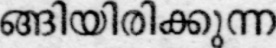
ങ്ങിയിരിക്കുന്ന
